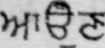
ਆਉਣ
